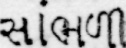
સાંભળી
